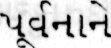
પૂર્વનાને
